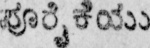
ಪೂರೈಕೆಯು
